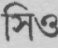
সিও
